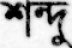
শন্দু
